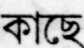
কাছে
